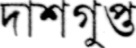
দাশগুপ্ত
